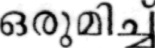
ഒരുമിച്ച്
